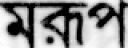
মরূপ
